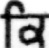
ਕਿ
